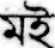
মই
